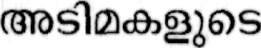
അടിമകളുടെ
